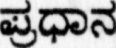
ಪ್ರಧಾನ
